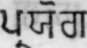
ਪ੍ਰਯੋਗ
